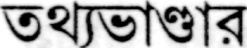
তথ্যভাণ্ডার
